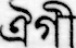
ঐগী
